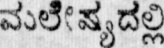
ಮಲೇಷ್ಯದಲ್ಲಿ
